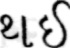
થઈ
